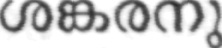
ശങ്കരനു
